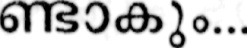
ണ്ടാകും...
